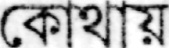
কোথায়
